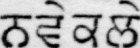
ਨਵੇਕਲੇ
